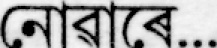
নোৱাৰে...
